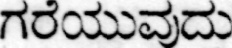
ಗರೆಯುವುದು
